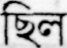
ছিল
